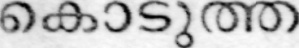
കൊടുത്ത
